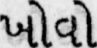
ખોવો
